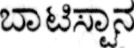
ಬಾಟಿಸ್ಟಾನ
